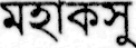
মহাকসু
